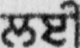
ਲਈ
